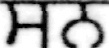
ਸਨ
